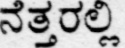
ನೆತ್ತರಲ್ಲಿ
